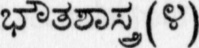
ಭೌತಶಾಸ್ತ್ರ(೪)
